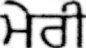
ਮੇਰੀ
